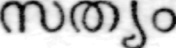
സത്യം
